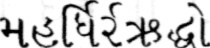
મહર્ધિ્રૠદ્ધો
